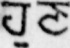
ਹੁਣ
